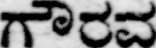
ಗೌರವ
